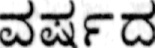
ವರ್ಷದ
